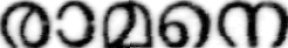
രാമനെ
